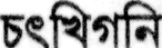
চৎখিগনি
